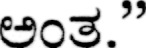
ಅಂತ."
